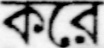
করে
